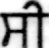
ਸੀ
